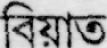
বিয়াত
